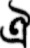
ঐ
